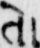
તો
